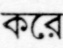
করে
